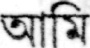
আমি
